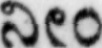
ನೀಂ
